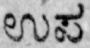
ಉಪ
